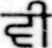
ਵੀ
